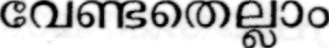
വേണ്ടതെല്ലാം
